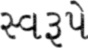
સ્વરૂપે
